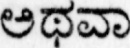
ಅಥವಾ
